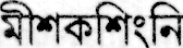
মীশকশিংনি
